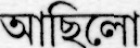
আছিলো
